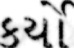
કર્યો
